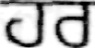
ਹਰ
